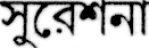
সুরেশনা
